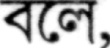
বলে,
